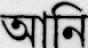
আনি
